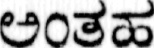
ಅಂತಹ
